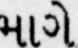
માગે
